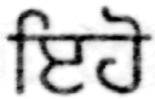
ਇਹੋ
